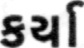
કર્યા
